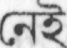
নেই
